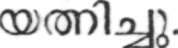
യത്നിച്ചു.
